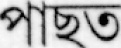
পাছত
